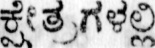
ಕ್ಷೇತ್ರಗಳಲ್ಲಿ
